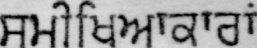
ਸਮੀਖਿਆਕਾਰਾਂ
